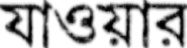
যাওয়ার
